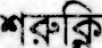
শরুক্নি
